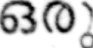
ഒരു
